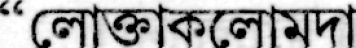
“লোক্তাকলোমদা
